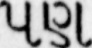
પણ
